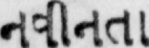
નવીનતા
